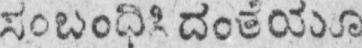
ಸಂಬಂಧಿಸಿದಂತೆಯೂ
